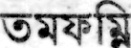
তমফম্নি
